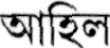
আহিল
